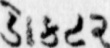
ડોક્ટર
